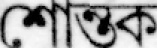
শোন্তক
